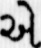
એ
